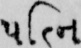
પત્નિ
